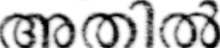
അതില്‍
